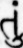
તું
